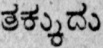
ತಕ್ಕುದು
